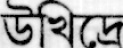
উখিদ্রে
